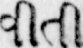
વીતી
